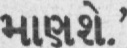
માણશે.'
